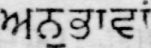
ਅਨੁਭਾਵਾਂ
